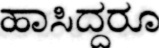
ಹಾಸಿದ್ದರೂ
